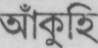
আঁকুহি
